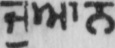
ਜੁਆਨ
